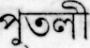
পুতলী
